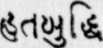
હતબુદ્ધિ
